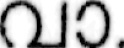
വാ.
